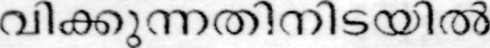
വിക്കുന്നതിനിടയില്‍
